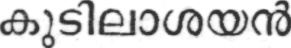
കുടിലാശയന്‍
